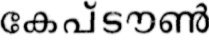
കേപ്ടൌണ്‍
